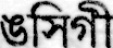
ঙসিগী
